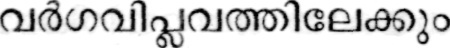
വര്‍ഗവിപ്ലവത്തിലേക്കും
